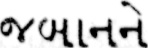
જબાનને
